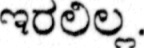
ಇರಲಿಲ್ಲ.
